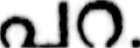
പറ.
